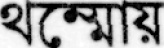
থম্মোয়
